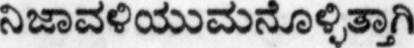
ನಿಜವಳಿಯಮನೊಳ್ಳಿತ್ತಾಗಿ
